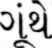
ગૂંથે
